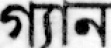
গ্যান
